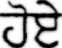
ਹੋਏ
